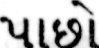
પાછો
